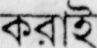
করাই
